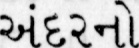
અંદરનો
